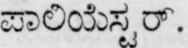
ಪಾಲಿಯೆಸ್ಟರ್.
